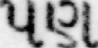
પણ
